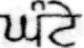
ਘੰਟੇ
